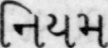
નિયમ
